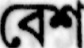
বেশ
